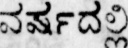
ವರ್ಷದಲ್ಲಿ
